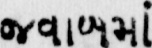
જવાબમાં
